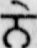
ਨੇ
